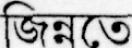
জিন্নতে
